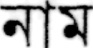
নাম
